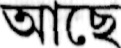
আছে
